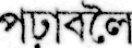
পঢ়াবলৈ
